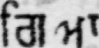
ਗਿਆ
